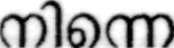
നിന്നെ
